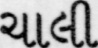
ચાલી
